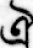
ঐ
